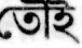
তৌই
